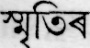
স্মৃতিৰ
